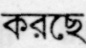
করছে
